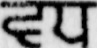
ਵਧ
